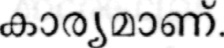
കാര്യമാണ്.
